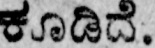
ಕೂಡಿದೆ.
